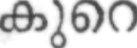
കുറെ
